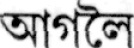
আগলৈ
